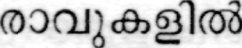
രാവുകളില്‍
